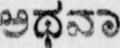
ಅಥವಾ
